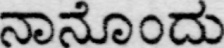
ನಾನೊಂದು
